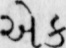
એક
